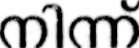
നിന്ന്
